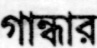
গান্ধার
